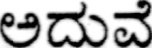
ಅದುವೆ
